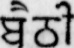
ਬੈਠੀ
